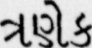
ત્રણેક
